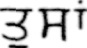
ਤੁਸਾਂ
